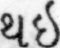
થઇ
